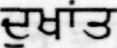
ਦੁਖਾਂਤ
